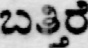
ಬತ್ತಿರೆ
